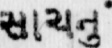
સાચનું
